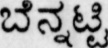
ಬೆನ್ನಟ್ಟಿ
